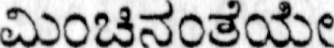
ಮಿಂಚಿನಂತೆಯೇ
